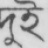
দুই
